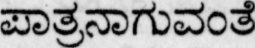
ಪಾತ್ರನಾಗುವಂತೆ
